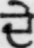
ਦੇ
